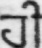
ਹੀ
